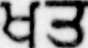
ਖਤ
